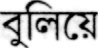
বুলিয়ে
